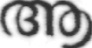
ആ
